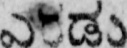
ಎರಡು
